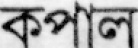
কপাল
